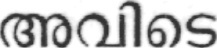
അവിടെ
